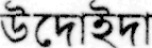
উদোইদা
